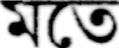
মতে
